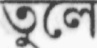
তুলে
